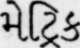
મેટ્રિક
